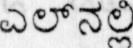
ಎಲ್‌ನಲ್ಲಿ
